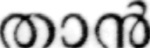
താന്‍
